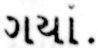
ગયાં.
